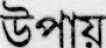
উপায়
